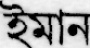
ইমান
